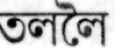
তললৈ
